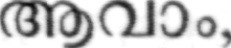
ആവാം,
